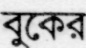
বুকের
